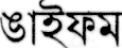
ঙাইফম
